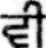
ਵੀ
